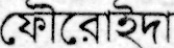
ফৌরোইদা
